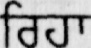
ਰਿਹਾ
